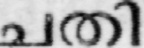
ചതി
